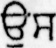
ਉਸ
